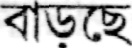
রাড়ছে
